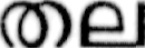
തല
